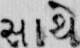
સાથે
